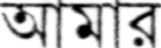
আমার
